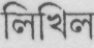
লিখিল
